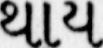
થાય
